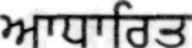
ਆਧਾਰਿਤ
